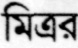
মিত্রর
